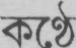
কণ্ঠে
